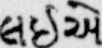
લઈએ
